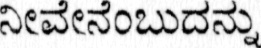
ನೀವೇನೆಂಬುದನ್ನು
